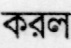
করল
